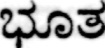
ಭೂತ
